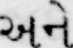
અને
